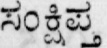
ಸಂಕ್ಷಿಪ್ತ
